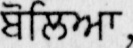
ਬੋਲਿਆ,
